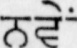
ਨਵੇਂ
